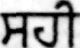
ਸਹੀ
